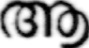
ആ
